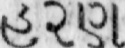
હરણ
